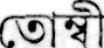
তোম্বী
